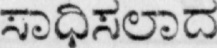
ಸಾಧಿಸಲಾದ
